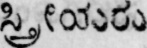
ಸ್ತ್ರೀಯರು
